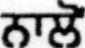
ਨਾਲੋਂ
